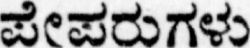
ಪೇಪರುಗಳು
